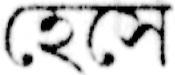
হেসে
